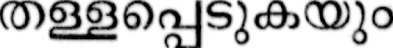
തള്ളപ്പെടുകയും
